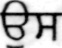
ਉਸ
